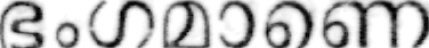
ഭംഗമാണെ
